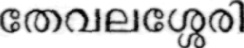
തേവലശ്ശേരി
